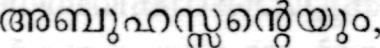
അബുഹസ്സന്റെയും,
